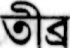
তীব্র
